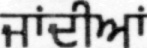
ਜਾਂਦੀਆਂ
